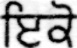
ਇਕੋ
